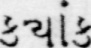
ક્યાંક
